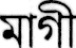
মাগী
